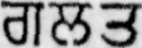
ਗਲਤ
